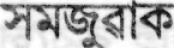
সমজুৱাক
